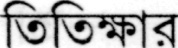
তিতিক্ষার
